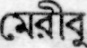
মেরীবু
